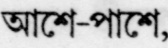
আশে-পাশে,
